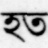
হত
